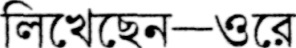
লিখেছেন–ওরে
